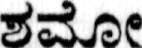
ಶಮೋ
